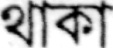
থাকা
